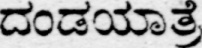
ದಂಡಯಾತ್ರೆ
